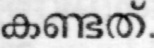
കണ്ടത്.
